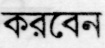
করবেন
